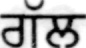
ਗੱਲ
